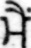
ਮੈਂ
